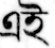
এই
